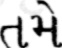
તમે
